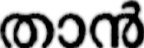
താന്‍
